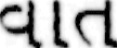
વાત
